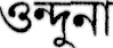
ওন্দুনা
